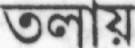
তলায়
